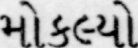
મોકલ્યો
